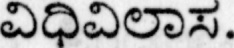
ವಿಧಿವಿಲಾಸ.
